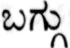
ಬಗ್ಗು
